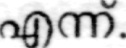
എന്ന്.
